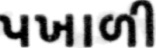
પખાળી
